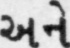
અને
